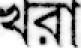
খরা
